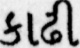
કાઢી
